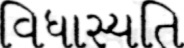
વિધાસ્યતિ
